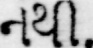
નથી.
